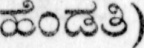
ಹೆಂಡತಿ)
